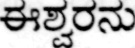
ಈಶ್ವರನು
